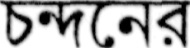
চন্দনের
